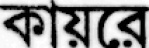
কায়রে
